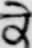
ਕੇ
